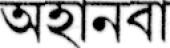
অহানবা
